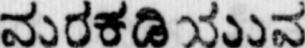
ಮರಕಡಿಯುವ
